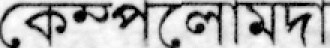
কেম্পলোমদা
